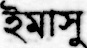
ইমাসু
